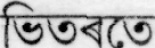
ভিতৰতে
